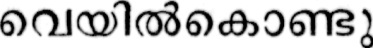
വെയില്‍കൊണ്ടു
